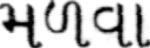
મળવા
